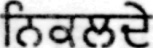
ਨਿਕਲਦੇ
